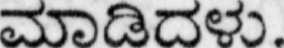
ಮಾಡಿದಳು.
